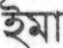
ইমা
